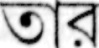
তার
